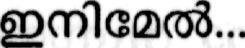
ഇനിമേല്‍..
